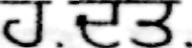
ਹ.ਦਤ.
